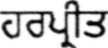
ਹਰਪ੍ਰੀਤ
